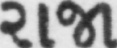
રાજા
